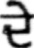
ਦੇ
